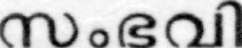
സംഭവി
